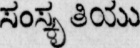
ಸಂಸ್ಕೃತಿಯು
